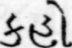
કહો
